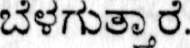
ಬೆಳಗುತ್ತಾರೆ.
